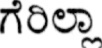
ಗೆರಿಲ್ಲಾ
